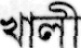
খালী
